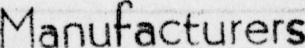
Manufactures
